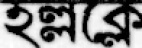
হল্লক্লে
